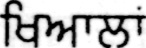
ਖਿਆਲਾਂ
